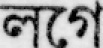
লগে
